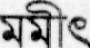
মমীৎ
